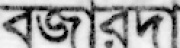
বজারদা
